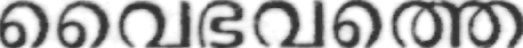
വൈഭവത്തെ
